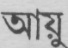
আয়ু
